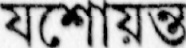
যশোয়ন্ত
